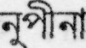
নুপীনা
